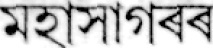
মহাসাগৰৰ
